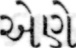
એણે
